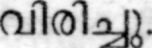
വിരിച്ചു.
